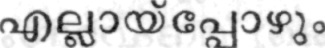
എല്ലായ്പ്പോഴും
